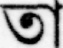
তা
